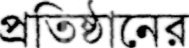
প্রতিষ্ঠানের
